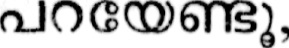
പറയേണ്ടൂ,
